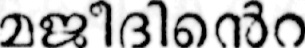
മജീദിന്റെ
